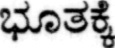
ಭೂತಕ್ಕೆ
